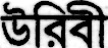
উরিবী
